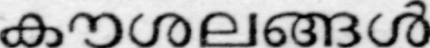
കൌശലങ്ങള്‍
